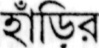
হাঁড়ির
